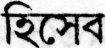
হিসেব
